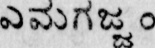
ಎಮಗಜ್ಜಂ
